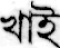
খাই
